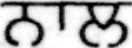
ਨਾਲ
